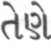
તેણે
